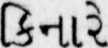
કિનારે
